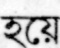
হয়ে
